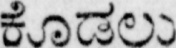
ಕೊಡಲು
